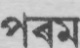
পৰম
